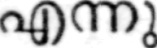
എന്നു
